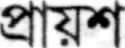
প্রায়শ
